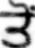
ਤੋਂ
